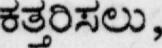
ಕತ್ತರಿಸಲು,
